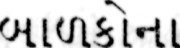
બાળકોના
